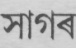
সাগৰ
